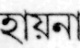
হায়না
